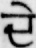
ਦੇ
